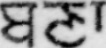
ਬਣਾ
